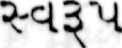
સ્વરૂપ
